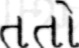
તતો
